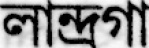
লান্দ্রগা
